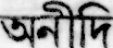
অনীদি
